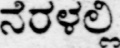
ನೆರಳಲ್ಲಿ
